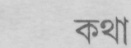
কথা
